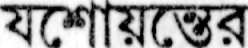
যশোয়ন্তের
